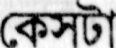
কেসটা
